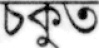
চকুত
